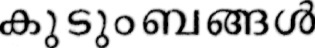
കുടുംബങ്ങള്‍
